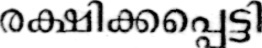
രക്ഷിക്കപ്പെട്ടി
